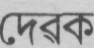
দেৱক
